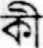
কী
